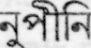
নুপীনি
